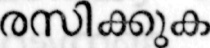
രസിക്കുക
